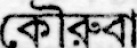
কৌরুবা
